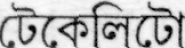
টেকেলিটো
